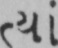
ત્યાં
